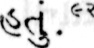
હતું.૯૨
